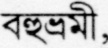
বহুভ্রমী,
